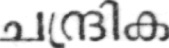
ചന്ദ്രിക
